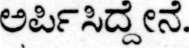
ಅರ್ಪಿಸಿದ್ದೇನೆ.
